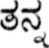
ತನ್ನ
